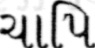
ચાપિ
